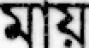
মায়
